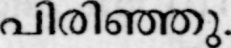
പിരിഞ്ഞു.
